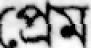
প্রেম
